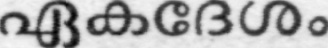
ഏകദേശം
